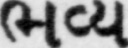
ભવ્ય
